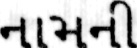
નામની
